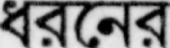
ধরনের
